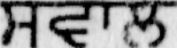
ਸਵਾਲ
